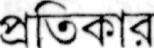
প্রতিকার
